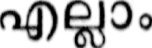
എല്ലാം
